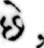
છે,
